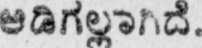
ಅಡಿಗಲ್ಲಾಗಿದೆ.
